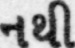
નથી
